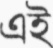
এই
